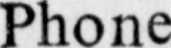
Phone
